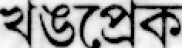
খঙপ্রেক
